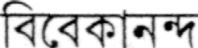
বিবেকানন্দ
